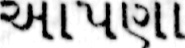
આપણા
